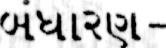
બંધારણ-
